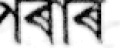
পৰাৰ
